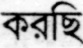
করছি
